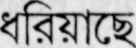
ধরিয়াছে
